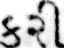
કરી
